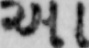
આ
